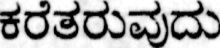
ಕರೆತರುವುದು
